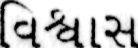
વિશ્વાસ
